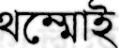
থম্মোই
